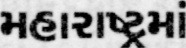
મહારાષ્ટ્રમાં
